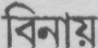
বিনায়
